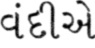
વંદીએ
